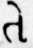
તે
